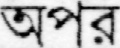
অপর
